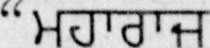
''ਮਹਾਰਾਜ
